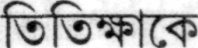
তিতিক্ষাকে
